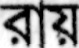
রায়
